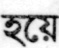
হয়ে
